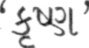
'કૃષ્ણ'
